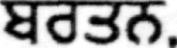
ਬਰਤਨ,
